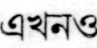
এখনও
